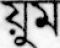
য়ুম
